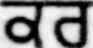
ਕਰ
